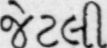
જેટલી
